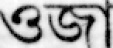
ওজা
